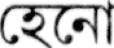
হেনো
